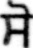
ਸੋ
